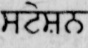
ਸਟੇਸ਼ਨ
